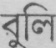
বুলি
